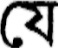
যে
